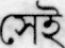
সেই
